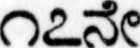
೧೭ನೇ
